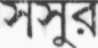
সসুর
